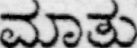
ಮಾತು
